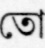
তো
